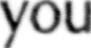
you
